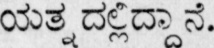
ಯತ್ನದಲ್ಲಿದ್ದಾನೆ.
